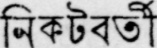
নিকটবর্তী
